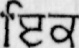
ਇਕ
